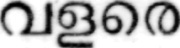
വളരെ
